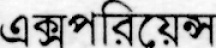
এক্সপরিয়েন্স
